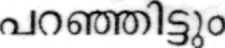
പറഞ്ഞിട്ടും
